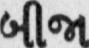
બીજા
